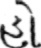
હો
